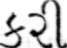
કરી
